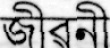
জীৱনী
